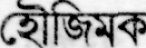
হৌজিমক
